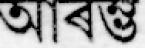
আৰম্ভ
